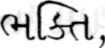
ભક્તિ,
